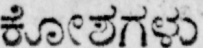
ಕೋಶಗಳು
